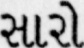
સારો
